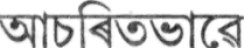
আচৰিতভাৱে
